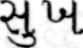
સુખ
